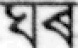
ঘৰ
